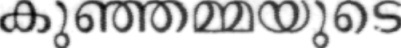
കുഞ്ഞമ്മയുടെ
